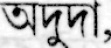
অদুদা,
